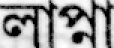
লাপ্না
